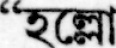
“হল্লো
